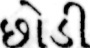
છોડી
